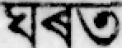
ঘৰত
